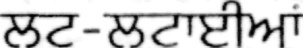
ਲਟ-ਲਟਾਈਆਂ
